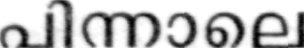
പിന്നാലെ
